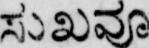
ಸುಖವೂ
